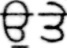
ਉਤੇ
